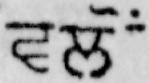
ਵਲੋਂ
